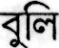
বুলি
